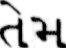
તેમ
